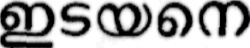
ഇടയനെ
